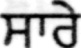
ਸਾਰੇ
